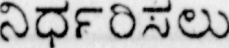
ನಿರ್ಧರಿಸಲು
